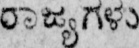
ರಾಜ್ಯಗಳು
